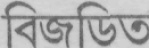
বিজড়িত
